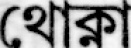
থোক্না
